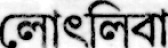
লোৎলিবা
